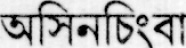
অসিনচিংবা
